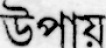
উপায়
